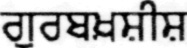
ਗੁਰਬਖ਼ਸ਼ੀਸ਼
